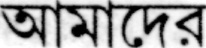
আমাদের
